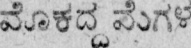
ಮೊಕದ್ದಮೆಗಳ
